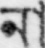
না
